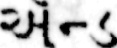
ઍન્ડ
